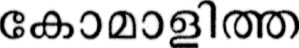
കോമാളിത്ത
